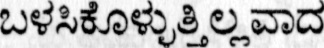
ಬಳಸಿಕೊಳ್ಳುತ್ತಿಲ್ಲವಾದ
